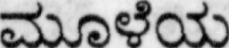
ಮೂಳೆಯ
